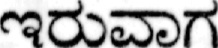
ಇರುವಾಗ
